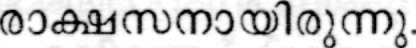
രാക്ഷസനായിരുന്നു.
